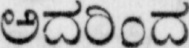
ಅದರಿಂದ
